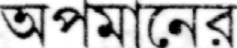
অপমানের
